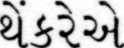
થેંકરેએ
